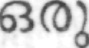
ഒരു
